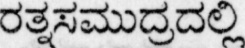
ರತ್ನಸಮುದ್ರದಲ್ಲಿ
